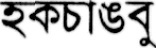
হকচাংবু
